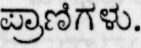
ಪ್ರಾಣಿಗಳು.
